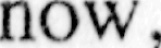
now,
